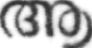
ആ
